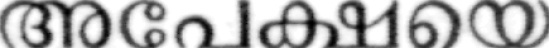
അപേക്ഷയെ
